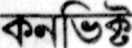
কনভিক্ট
